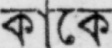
কাকে
